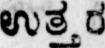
ಉತ್ತರ
